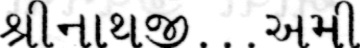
શ્રીનાથજી..અમી
